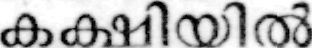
കക്ഷിയില്‍
